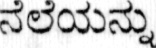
ನೆಲೆಯನ್ನು
